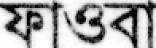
ফাওবা
